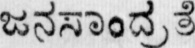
ಜನಸಾಂದ್ರತೆ
